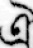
ঐ
